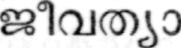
ജീവത്യാ
